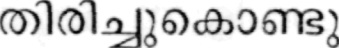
തിരിച്ചുകൊണ്ടു
